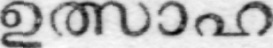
ഉത്സാഹ
